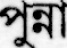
পুন্না
